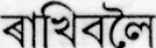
ৰাখিবলৈ
